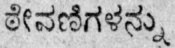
ಠೇವಣಿಗಳನ್ನು
